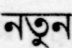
নতুন
